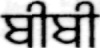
ਬੀਬੀ
